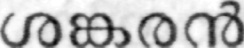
ശങ്കരന്‍
